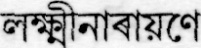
লক্ষ্মীনাৰায়ণে
